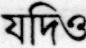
যদিও
